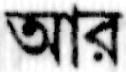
আর
